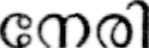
നേരി
